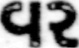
વર
